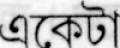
একেটা
